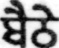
ਬੈਠੇ
